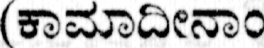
(ಕಾಮಾದೀನಾಂ
